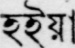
হইয়া
